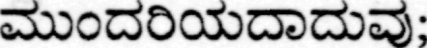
ಮುಂದರಿಯದಾದುವು;
